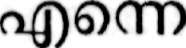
എന്നെ
